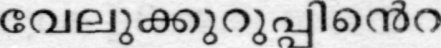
വേലുക്കുറുപ്പിന്റെ
